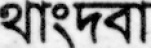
থাংদবা
